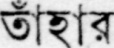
তাঁহার
